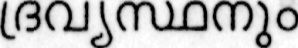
ദ്രവ്യസ്ഥനും
